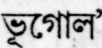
ভূগোল’
